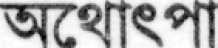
অথোৎপা
